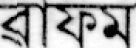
ৱাফম
